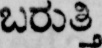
ಬರುತ್ತಿ
